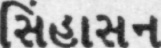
સિંહાસન
